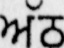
ਅੱਠ
